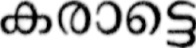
കരാട്ടെ
